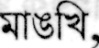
মাঙখি,
